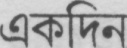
একদিন
